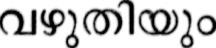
വഴുതിയും
